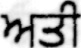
ਅਤੀ
